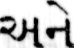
અને
